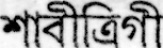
শাবীত্রিগী
